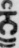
ਨੂੰ
